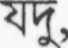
যদু,
